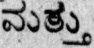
ಮತ್ತು
